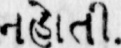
નહોતી.
